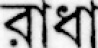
রাধা
